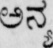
ಅನ್ಯ
